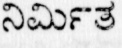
ನಿರ್ಮಿತ
